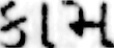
કામ
